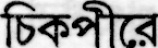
চিকপীরে
